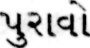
પુરાવો
